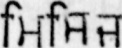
ਮਿਸਿਜ
